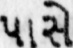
પાસે
